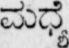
ಮಧ್ಯೆ
